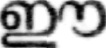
ഈ
